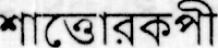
শাত্তোরকপী
